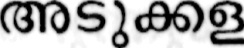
അടുക്കള
